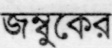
জম্বুকের
